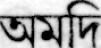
অমদি
